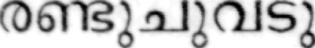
രണ്ടുചുവടു
